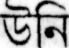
উনি
